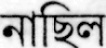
নাছিল
